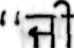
''ਜੀ
